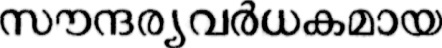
സൌന്ദര്യവര്‍ധകമായ
